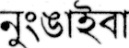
নুংঙাইবা
